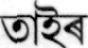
তাইৰ
